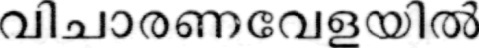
വിചാരണവേളയില്‍
